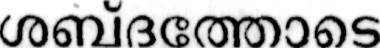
ശബ്ദത്തോടെ
